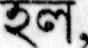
হল,
